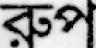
রুপ
